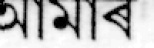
আমাৰ
